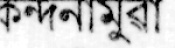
কন্দনামুৱা
